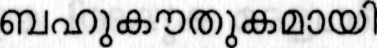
ബഹുകൌതുകമായി
